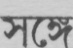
সঙ্গে
